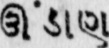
ઊંડાણ
